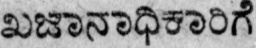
ಖಜಾನಾಧಿಕಾರಿಗೆ
